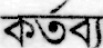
কর্তব্য
